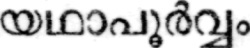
യഥാപൂര്‍വ്വം
